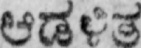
ಆಡಳಿತ
